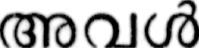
അവള്‍
